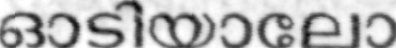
ഓടിയാലോ
